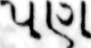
પણ
